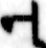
ન
